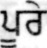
ਪੂਰੇ
